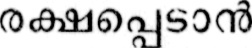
രക്ഷപ്പെടാന്‍
